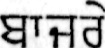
ਬਾਜਰੇ
